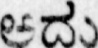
ಅದು
